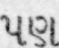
પણ
